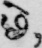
છે,
